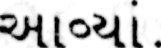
આવ્યાં.
